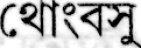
থোংবসু
